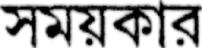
সময়কার
